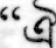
“ঐ
